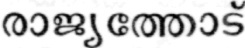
രാജ്യത്തോട്
